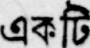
একটি
